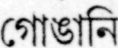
গোঙানি
